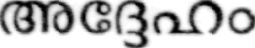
അദ്ദേഹം
